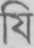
যি
